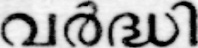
വര്‍ദ്ധി
